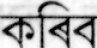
কৰিব
